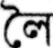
লৈ
